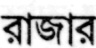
রাজার
